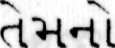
તેમનો
